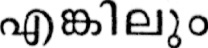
എങ്കിലും
